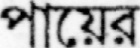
পায়ের
